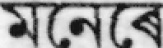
মনেৰে
